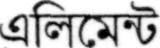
এলিমেন্ট
